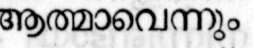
ആത്മാവെന്നും
